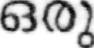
ഒരു
